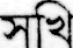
সখি
